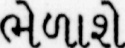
ભેળાશે
